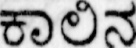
ಕಾಲಿನ
